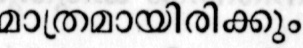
മാത്രമായിരിക്കും
